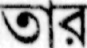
তার
